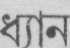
ধ্যান
